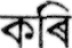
কৰি
